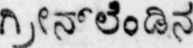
ಗ್ರೀನ್‌ಲೆಂಡಿನ
